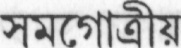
সমগোত্রীয়
